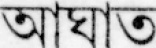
আঘাত
